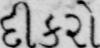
દીકરો
